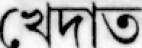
খেদাত
